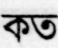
কত
